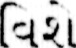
વિશે
